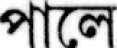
পালে
